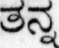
ತನ್ನ
